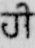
ਹੀ
